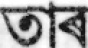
তাৰ
